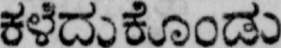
ಕಳೆದುಕೊಂಡು
